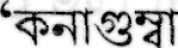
‘কনাগুম্বা
